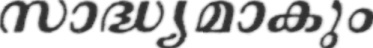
സാദ്ധ്യമാകും
